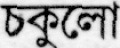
চকুলো
